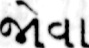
જોવા
